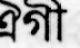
ঐগী
